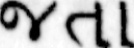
જતા
